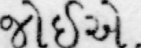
જોઈએ.
